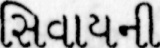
સિવાયની
